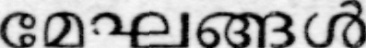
മേഘങ്ങള്‍
